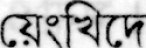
য়েংখিদে
